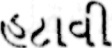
હટાવી
